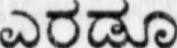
ಎರಡೂ
